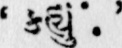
'કહ્યું.'
